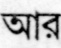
আর
